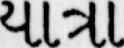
યાત્રા
